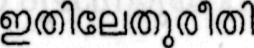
ഇതിലേതുരീതി
